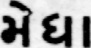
મેધા
